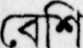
বেশি
